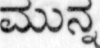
ಮುನ್ನ
